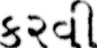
કરી
